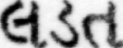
લડત
